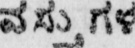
ವಸ್ತುಗಳ
